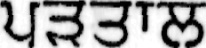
ਪੜਤਾਲ
